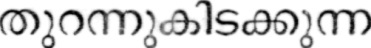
തുറന്നുകിടക്കുന്ന
